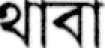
থাবা
